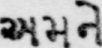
અમને
